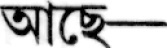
আছে-
